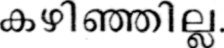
കഴിഞ്ഞില്ല.
